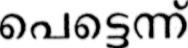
പെട്ടെന്ന്
